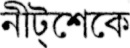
নীট্‌শেকে
